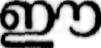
ഈ
